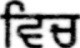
ਵਿਚ
